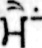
ਮੈਂ
